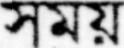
সময়
